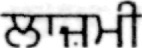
ਲਾਜ਼ਮੀ
